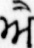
ਐ
